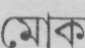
মোক
